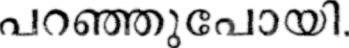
പറഞ്ഞുപോയി.
